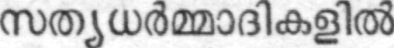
സത്യധര്‍മ്മാദികളില്‍
